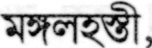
মঙ্গলহস্তী,
